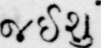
જઈશું
